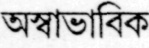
অস্বাভাবিক
